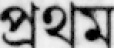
প্রথম
